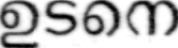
ഉടനെ
